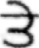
ਤੇ
